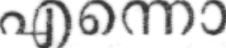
എന്നൊ
